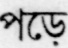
পড়ে
